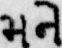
મને
